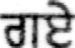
ਗਏ
